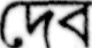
দেব
